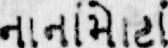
નાનાંમોટા
